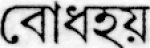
বোধহয়
